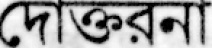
দোক্তরনা
